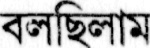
বলছিলাম
